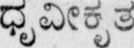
ಧೃವೀಕೃತ
